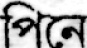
পিনে
